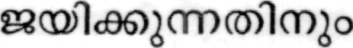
ജയിക്കുന്നതിനും
